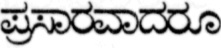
ಪ್ರಸಾರವಾದರೂ
